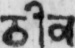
ਠੀਕ
